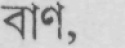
বাণ,
